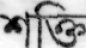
শক্তি
